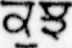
ਕੁਝ
